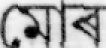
মোৰ
